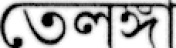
তেলঙ্গা
